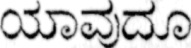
ಯಾವುದೂ
